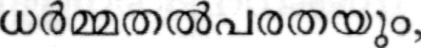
ധര്‍മ്മതല്‍പരതയും,
